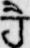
ਹੈ
